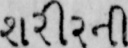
શરીરની
